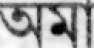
অমা
